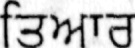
ਤਿਆਰ
